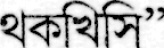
থকখিসি”
